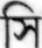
সি
